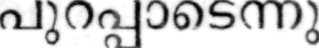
പുറപ്പാടെന്നു
